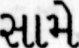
સામે
